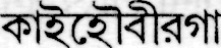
কাইহৌবীরগা
